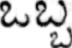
ಒಬ್ಬ
